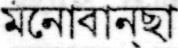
মনোবান্‌ছা
